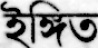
ইঙ্গিত
